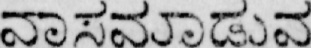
ವಾಸಮಾಡುವ
